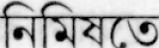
নিমিষতে
